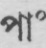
পা
